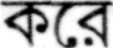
করে
